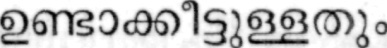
ഉണ്ടാക്കീട്ടുള്ളതും
